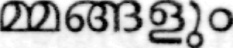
മ്മങ്ങളും
